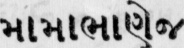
મામાભાણેજ
